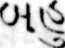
બહુ
